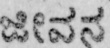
ಜೀವನ
